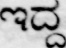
ಇದ್ದ
